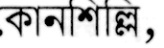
কোনশিল্লি,
